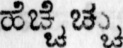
ಹೆಚ್ಚೆಚ್ಚು
